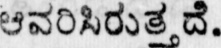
ಆವರಿಸಿರುತ್ತದೆ.
